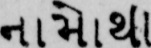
નામોથી
